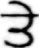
ਤੇ
